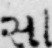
ની
